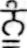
ਨੂੰ
